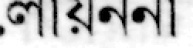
লোয়ননা
